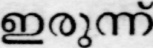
ഇരുന്ന്
